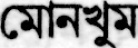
মোনখুম
